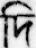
দি
